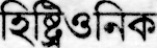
হিষ্ট্রিওনিক
